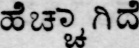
ಹೆಚ್ಚಾಗಿದೆ
